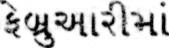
ફેબ્રુઆરીમાં
